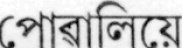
পোৱালিয়ে
